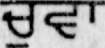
ਚੁਵਾ
